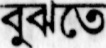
বুঝতে
